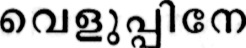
വെളുപ്പിനേ
